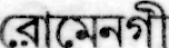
রোমেনগী
